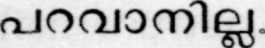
പറവാനില്ല.
